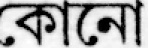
কোনো
